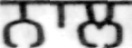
ਨਾਲ
